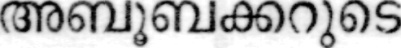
അബൂബക്കറുടെ
